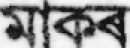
মাকৰ
